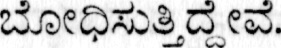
ಬೋಧಿಸುತ್ತಿದ್ದೇವೆ.
